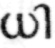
ധി
